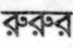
রুরুর
